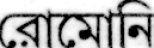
রোমোনি
